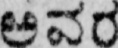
ಅವರ
